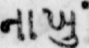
નાખું
